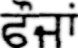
ਫੌਜਾਂ
